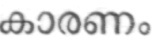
കാരണം
